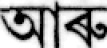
আৰু
